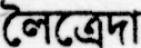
লৈত্রেদা
